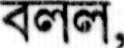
বলল,
